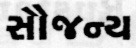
સૌજન્ય
